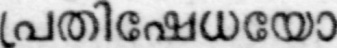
പ്രതിഷേധയോ
